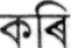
কৰি
